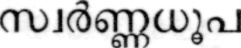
സ്വര്‍ണ്ണധൂപ
